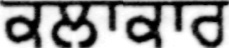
ਕਲਾਕਾਰ
